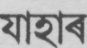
যাহাৰ
